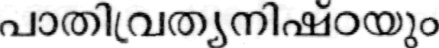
പാതിവ്രത്യനിഷ്ഠയും
